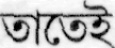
তাতেই
